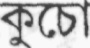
কুচো
